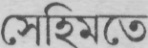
সেহিমতে
